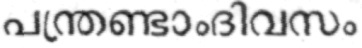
പന്ത്രണ്ടാംദിവസം
